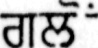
ਗਲੋਂ
